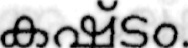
കഷ്ടം.
